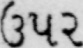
ઉપર
